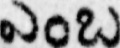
ಎಂಬ
